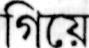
গিয়ে
